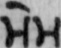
ਮੇਮ
